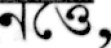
নত্তে,
